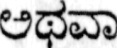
ಅಥವಾ
